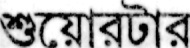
শুয়োরটার
